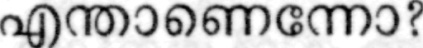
എന്താണെന്നോ?
